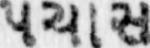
પચાસ
